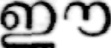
ഈ
